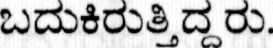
ಬದುಕಿರುತ್ತಿದ್ದರು.
